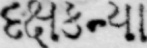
દક્ષકન્યા
